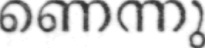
ണെന്നു
